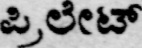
ಪ್ರಿಲೇಟ್
